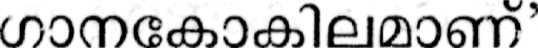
ഗാനകോകിലമാണ്'
